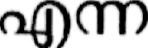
എന്ന
